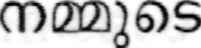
നമ്മുടെ
